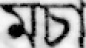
মচা
